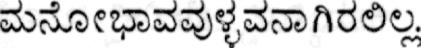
ಮನೋಭಾವವುಳ್ಳವನಾಗಿರಲಿಲ್ಲ.
